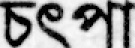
চৎপা
